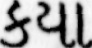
ક્યા
